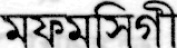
মফমসিগী
